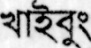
খাইবুং
